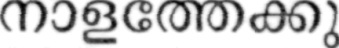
നാളത്തേക്കു
